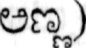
ಅಣ್ಣ)
